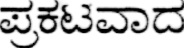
ಪ್ರಕಟವಾದ
